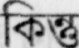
কিন্তু
